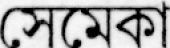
সেমেকা
